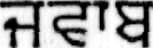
ਜਵਾਬ
